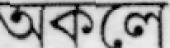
অকলে
